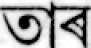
তাৰ
